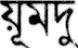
য়ুমদু
